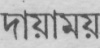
দায়াময়
